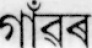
গাঁৱৰ
